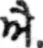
ਐ,
